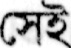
সেই
